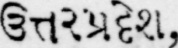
ઉત્તરપ્રદેશ,
